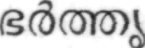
ഭര്‍ത്തൃ
